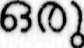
ഒരു
